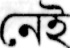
নেই
